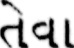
તેવા
